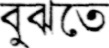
বুঝতে
